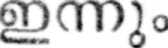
ഇന്നും
